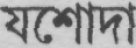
যশোদা
